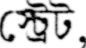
স্ট্রেট,
